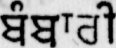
ਬੰਬਾਰੀ
